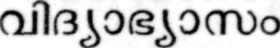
വിദ്യാഭ്യാസം
